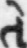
તે
